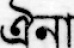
ঐনা
